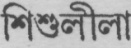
শিশুলীলা
